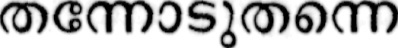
തന്നോടുതന്നെ
